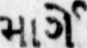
માર્ગે
